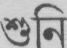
শুনি
